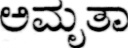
ಅಮೃತಾ
